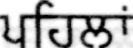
ਪਹਿਲਾਂ
